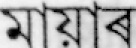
মায়াৰ
